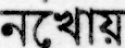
নখোয়
